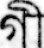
গী
